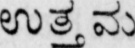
ಉತ್ತಮ
